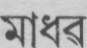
মাধৱ
